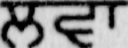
ਲਵਾ
